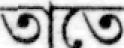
তাতে
